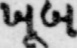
ખૂબ
